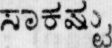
ಸಾಕಷ್ಟು
